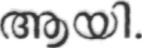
ആയി.
